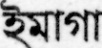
ইমাগা
